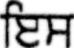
ਇਸ
